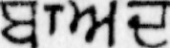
ਬਾਅਦ
